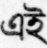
এই
